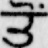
ਤੋਂ
